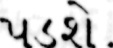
પડશે.
